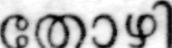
തോഴി
